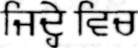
ਜਿਦ੍ਹੇਵਿਚ
